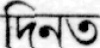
দিনত
